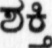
ಶಕ್ತಿ
